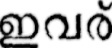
ഇവര്
